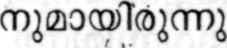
നുമായിരുന്നു
